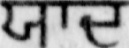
ਯਾਦ
